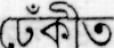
ঢেঁকীত
